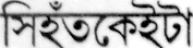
সিহঁতকেইটা
